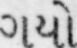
ગયો
